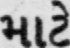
માટે
